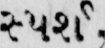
સ્પર્શ,
